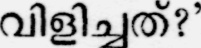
വിളിച്ചത്?'
